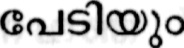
പേടിയും
